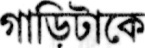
গাড়িটাকে
